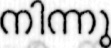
നിന്നു
